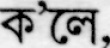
ক'লে,
